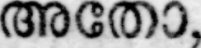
അതോ,
